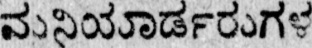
ಮನಿಯಾರ್ಡರುಗಳ
